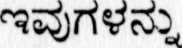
ಇವುಗಳನ್ನು
